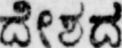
ದೇಶದ
